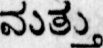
ಮತ್ತು
